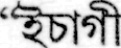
“ইচাগী
